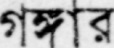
গঙ্গার
